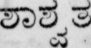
ಶಾಶ್ವತ
